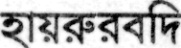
হায়রুরবদি
